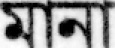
মানা
